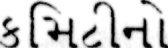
કમિટીનો
